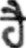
ਹੈ
